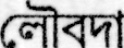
লৌবদা
